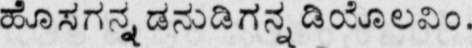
ಹೊಸಗನ್ನಡನುಡಿಗನ್ನಡಿಯೊಲವಿಂ.
